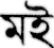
মই
